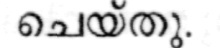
ചെയ്തു.
